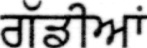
ਗੱਡੀਆਂ
